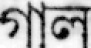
গাল
